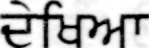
ਦੇਖਿਆ
